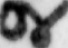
જ
